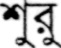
শুরু
